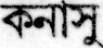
কনাসু
